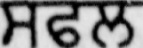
ਸਫਲ
